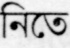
নিতে
